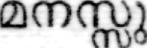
മനസ്സു
